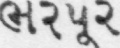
ભરપૂર
